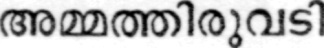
അമ്മത്തിരുവടി
